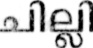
ചില്ലി
